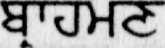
ਬ੍ਰਾਹਮਣ
